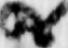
જ
